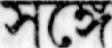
সঙ্গে
